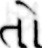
તો
